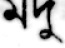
মদু
